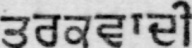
ਤਰਕਵਾਦੀ
